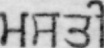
ਮਸਤੀ
